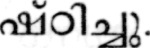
ഷ്ഠിച്ചു.
